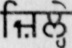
ਜ਼ਿਲ੍ਹੇ
